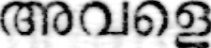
അവളെ
